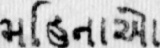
મહિનાઓ
